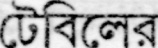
টেবিলের
